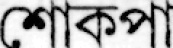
শোকপা
